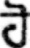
ਹੋ
